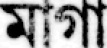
মাগা
